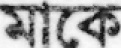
মাকে
